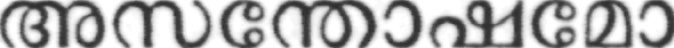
അസന്തോഷമോ
